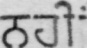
ਨਹੀਂ
